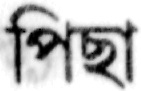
পিছা
